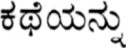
ಕಥೆಯನ್ನು
